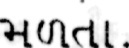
મળતા.
